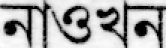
নাওখন
